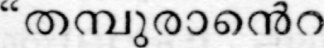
"തമ്പുരാന്റെ
